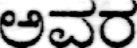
ಅವರ
